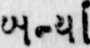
બન્યાં
